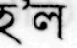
হ'ল
